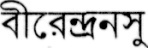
বীরেন্দ্রনসু
